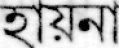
হায়না
